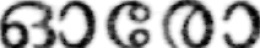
ഓരോ
